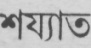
শয্যাত
